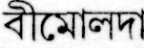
বীমোলদা
